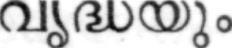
വൃദ്ധയും
